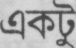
একটু
